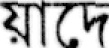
য়াদে
